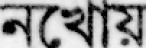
নখোয়
